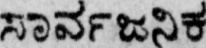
ಸಾರ್ವಜನಿಕ
